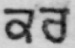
ਕਰ
